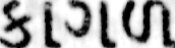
કાગળ
